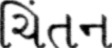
ચિંતન
